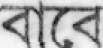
বাবে
